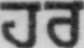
ਹਰ
